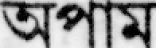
অপাম
